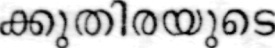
ക്കുതിരയുടെ
